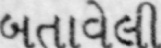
બતાવેલી
